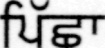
ਪਿੱਛਾ
